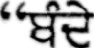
''ਬੰਦੇ
